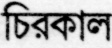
চিরকাল
